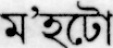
ম'হটো
